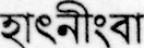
হাৎনীংবা
